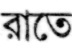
রাতে
